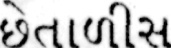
છેતાળીસ
